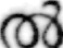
ല്‍
